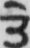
ਤੇ
